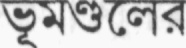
ভূমণ্ডলের
